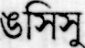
ঙসিসু
